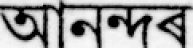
আনন্দৰ
